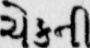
ચેકની
